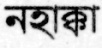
নহাক্কা
